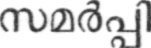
സമര്‍പ്പി
